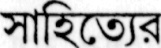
সাহিত্যের
